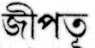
জীপতূ
